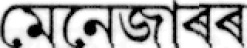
মেনেজাৰৰ
